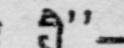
ਹੈ
